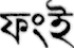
ফংই
